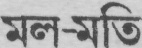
মল-মতি
